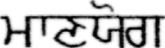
ਮਾਣਯੋਗ
